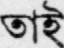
তাই
